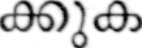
ക്കുക
